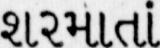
શરમાતાં
